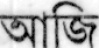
আজি
